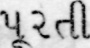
પૂરતી
